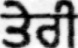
ਤੇਰੀ
